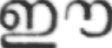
ഈ
